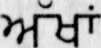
ਅੱਖਾਂ
